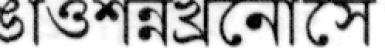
ঙাওশন্নখ্রনোসে
